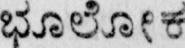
ಭೂಲೋಕ
